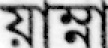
য়াম্না
